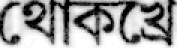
থোকখ্রে
